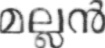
മല്ലന്‍
